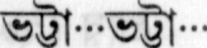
ভট্টা...ভট্টা...
